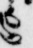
હું
